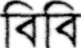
বিবি
